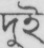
দুই
